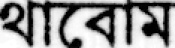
থাবোম
